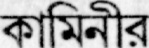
কামিনীর
